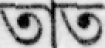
তাত
